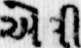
એવી
